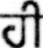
ਹੀ
